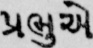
પ્રભુએ
